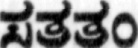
ಸತತಂ
